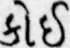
કોઈ
